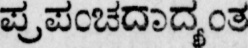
ಪ್ರಪಂಚದಾದ್ಯಂತ
